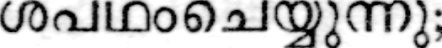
ശപഥംചെയ്യുന്നു;
